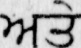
ਅਤੇ
